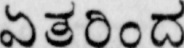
ಏತರಿಂದ
